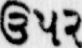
ઉપર
